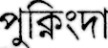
পুক্নিংদা
